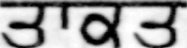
ਤਾਕਤ
